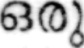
ഒരു
